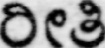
ರೀತಿ
